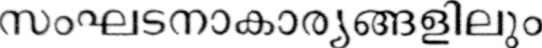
സംഘടനാകാര്യങ്ങളിലും
